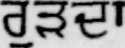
ਰੁੜਦਾ
